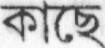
কাছে
